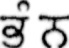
ਭੰਨ
